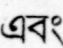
এবং
